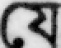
যে
